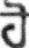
ਹੋ
